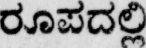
ರೂಪದಲ್ಲಿ
